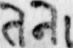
તેનો
